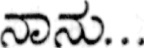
ನಾನು...
